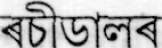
ৰচীডালৰ
